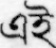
এই
